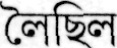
লৈছিল
